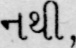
નથી,
